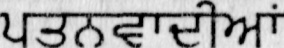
ਪਤਨਵਾਦੀਆਂ
